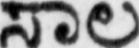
ಸಾಲ
